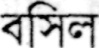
বসিল
